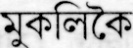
মুকলিকৈ
